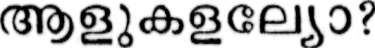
ആളുകളല്യോ?
